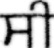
ਸੀ
